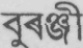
বুৰঞ্জী
